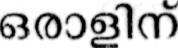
ഒരാളിന്
